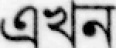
এখন
